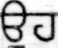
ਉਹ
